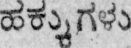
ಹಕ್ಕುಗಳು
